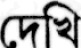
দেখি
